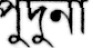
পুদুনা
